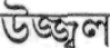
উজ্জ্বল
